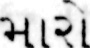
મારો
